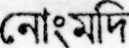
নোংমদি
